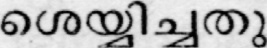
ശെയ്യിച്ചതു
